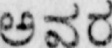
ಅವರ
